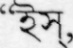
"ইস্‌,
